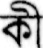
কী
